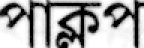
পাক্লপ
